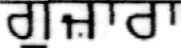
ਗੁਜ਼ਾਰਾ
